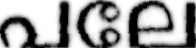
പലേ
